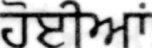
ਹੋਈਆਂ
